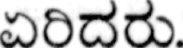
ಏರಿದರು.
